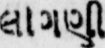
લાગણી
